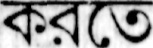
করতে
